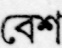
বেশ
